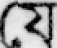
যে
